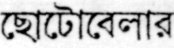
ছোটোবেলার
